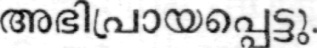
അഭിപ്രായപ്പെട്ടു.
